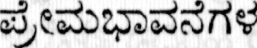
ಪ್ರೇಮಭಾವನೆಗಳ
